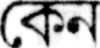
কেন
